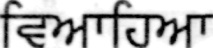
ਵਿਆਹਿਆ
